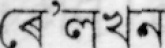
ৰে'লখন
